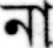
না
